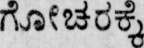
ಗೋಚರಕ್ಕೆ
